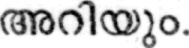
അറിയും.
